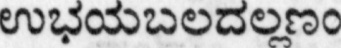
ಉಭಯಬಲದಲ್ಲಣಂ
